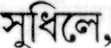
সুধিলে,
